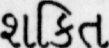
શક્તિ
